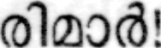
രിമാര്‍!
